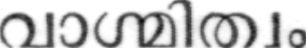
വാഗ്മിത്വം
